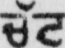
ਚੱਟ
